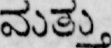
ಮತ್ತು
